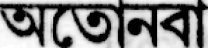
অতোনবা
